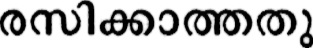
രസിക്കാത്തതു
